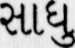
સાધુ
